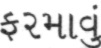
ફરમાવું
